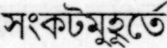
সংকটমুহূর্তে
